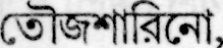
তৌজশারিনো,
